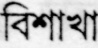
বিশাখা
